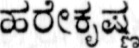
ಹರೇಕೃಷ್ಣ
